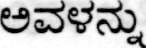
ಅವಳನ್ನು
